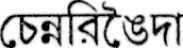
চেন্নরিঙৈদা
